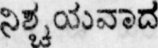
ನಿಶ್ಚಯವಾದ
